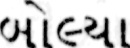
બોલ્યા
